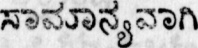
ಸಾಮಾನ್ಯವಾಗಿ
